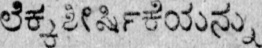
ಲೆಕ್ಕಶೀರ್ಷಿಕೆಯನ್ನು
